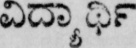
ವಿದ್ಯಾರ್ಥಿ
